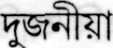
দুজনীয়া
